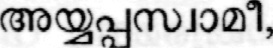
അയ്യപ്പസ്വാമീ,
